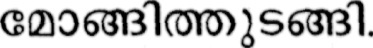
മോങ്ങിത്തുടങ്ങി.
